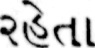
રહેતા
